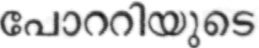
പോററിയുടെ
